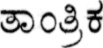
ತಾಂತ್ರಿಕ
